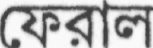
ফেরাল
